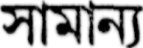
সামান্য
